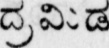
ದ್ರಮಿಡ
